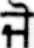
ਜੋ
